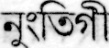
নুংতিগী
